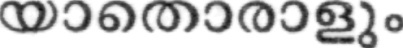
യാതൊരാളും
